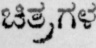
ಚಿತ್ರಗಳ
